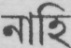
নাহি
